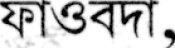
ফাওবদা,
